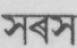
সৰস
